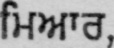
ਮਿਆਰ,
